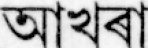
আখৰা
